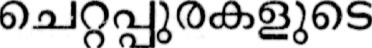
ചെറ്റപ്പുരകളുടെ
